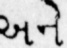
અને
